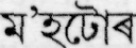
ম'হটোৰ
